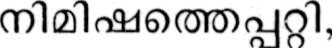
നിമിഷത്തെപ്പറ്റി,
